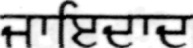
ਜਾਇਦਾਦ
